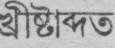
খ্ৰীষ্টাব্দত
